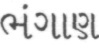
ભંગાણ
